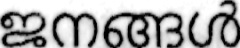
ജനങ്ങള്‍
